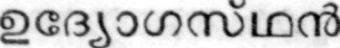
ഉദ്യോഗസ്ഥന്‍
